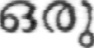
ഒരു
